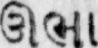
ઊભા
